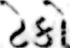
ટેકો
